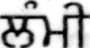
ਲੰਮੀ
